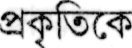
প্রকৃতিকে
